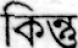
কিন্তু
